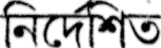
নির্দেশিত
